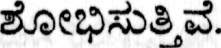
ಶೋಭಿಸುತ್ತಿವೆ.
